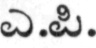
ಎ.ಪಿ.
